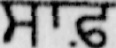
ਸਾਫ਼
